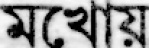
মখোয়
